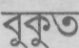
বুকুত
